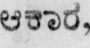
ಆಕಾರ,
